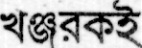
খঞ্জরকই
